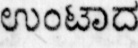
ಉಂಟಾದ
